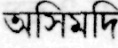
অসিমদি
